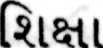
શિક્ષા
